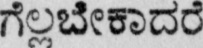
ಗೆಲ್ಲಬೇಕಾದರೆ
